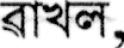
ৱাখল,
